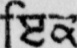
ਇਕ
